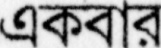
একবার
